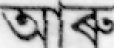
আৰু
